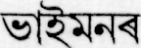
ভাইমনৰ
